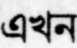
এখন
